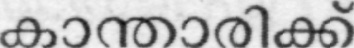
കാന്താരിക്ക്
